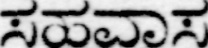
ಸಹವಾಸ
